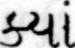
ક્યાં
